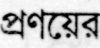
প্রণয়ের
